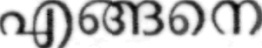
എങ്ങനെ
